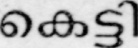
കെട്ടി
